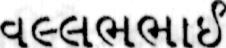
વલ્લભભાઈ
